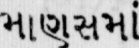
માણસમાં
